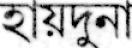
হায়দুনা
